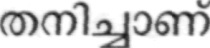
തനിച്ചാണ്
